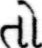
તો
